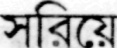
সরিয়ে
